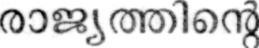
രാജ്യത്തിന്റെ
